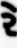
રે
